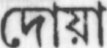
দোয়া
